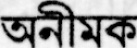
অনীমক
